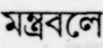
মন্ত্রবলে
